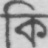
কি
